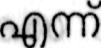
എന്ന്
